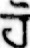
ਹੋ
